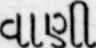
વાણી
